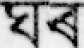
ঘৰ
